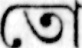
তো
